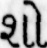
શો
